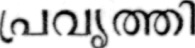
പ്രവൃത്തി
